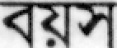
বয়স
